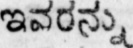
ಇವರನ್ನು
